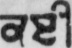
ਕਈ
